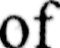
of
